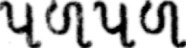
પળપળ
